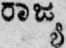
ರಾಜ್ಯ
